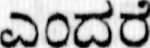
ಎಂದರೆ
